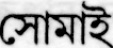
সোমাই
